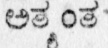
ಅತ್ಯಂತ
